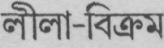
লীলা-বিক্ৰম
